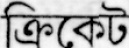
ক্ৰিকেট
